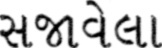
સજાવેલા
